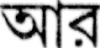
আর
